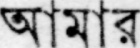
আমার
